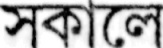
সকালে
